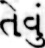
તેવું
